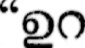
“ഉറ
